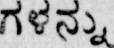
ಗಳನ್ನು
